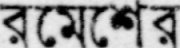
রমেশের
